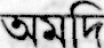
অমদি
